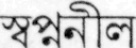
স্বপ্ননীল
